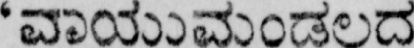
‘ವಾಯುಮಂಡಲದ
